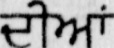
ਦੀਆਂ
